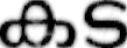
കട
